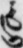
હું
